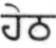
ਹੇਠ
